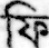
ফি
